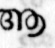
ആ
